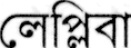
লেপ্লিবা
